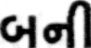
બની
